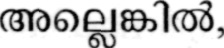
അല്ലെങ്കില്‍,
